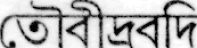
তৌবীদ্রবদি
